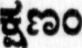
ಕ್ಷಣಂ
